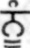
ਨੂੰ
